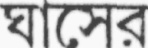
ঘাসের
